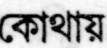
কোথায়
